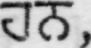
ਹਨ,
